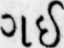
ગઈ
